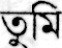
তুমি
